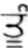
ਤੂੰ
